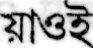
য়াওই
